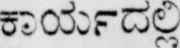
ಕಾರ್ಯದಲ್ಲಿ
